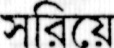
সরিয়ে
